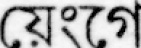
য়েংগে
